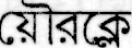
য়ৌরক্লে
